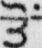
ਤੋਂ
